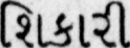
શિકારી
